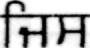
ਜਿਸ
